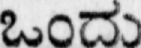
ಒಂದು
